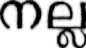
നല്ല
